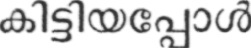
കിട്ടിയപ്പോള്‍
